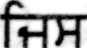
ਜਿਸ
